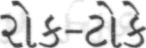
રોક-ટોકે
